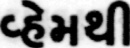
વ્હેમથી
